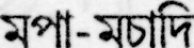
মপা-মচাদি
